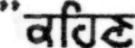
''ਕਹਿਣ
